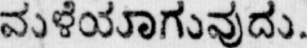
ಮಳೆಯಾಗುವುದು.
